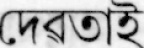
দেৱতাই
